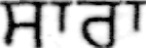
ਸਾਰਾ
